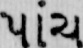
પાંચ)
